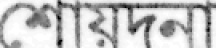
শোয়দনা
